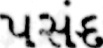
પસંદ
